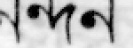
নন্দন
